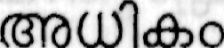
അധികം
